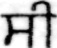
ਸੀ
